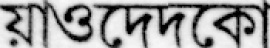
য়াওদেদকো
